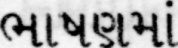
ભાષણમાં
